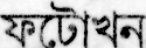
ফটোখন
